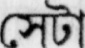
সেটা
